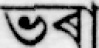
ভৰা
